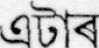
এটাৰ
